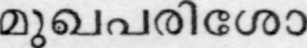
മുഖപരിശോ
